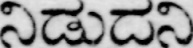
ನಿಡುದನಿ
